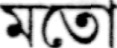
মতো
